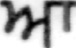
ਆ
